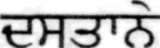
ਦਸਤਾਨੇ
